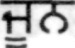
ਜੂਨ
